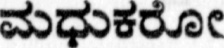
ಮಧುಕರೋ
